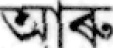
আৰু
